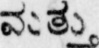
ಮತ್ತು
